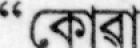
"কোৱা
